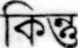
কিন্তু
